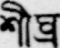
শীঘ্র
